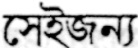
সেইজন্য
